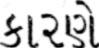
કારણે
